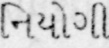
નિયોગી
